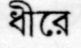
ধীরে
